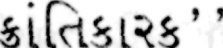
ક્રાંતિકારક"
